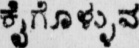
ಕೈಗೊಳ್ಳಿವ
